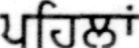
ਪਹਿਲਾਂ
